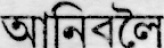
আনিবলৈ
